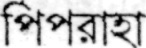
পিপরাহা
